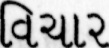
વિચાર
